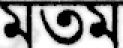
মতম
